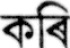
কৰি
